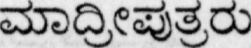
ಮಾದ್ರೀಪುತ್ರರು
